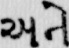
અને
